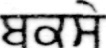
ਬਕਸੇ
